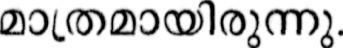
മാത്രമായിരുന്നു.
